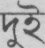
দুই
